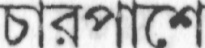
চারপাশে
